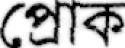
প্রোক
